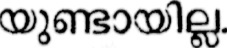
യുണ്ടായില്ല.
